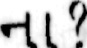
ના?
